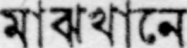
মাঝখানে
